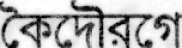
কৈদৌরগে
